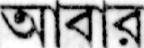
আবার
